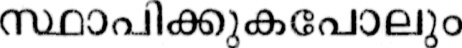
സ്ഥാപിക്കുകപോലും
